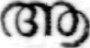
ആ
